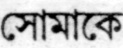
সোমাকে
